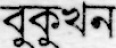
বুকুখন
